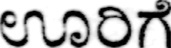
ಊರಿಗೆ
